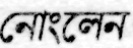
নোংলেন
